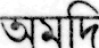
অমদি
